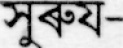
সুৰুয-
